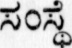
ಸಂಸ್ಥೆ
